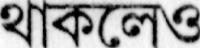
থাকলেও
